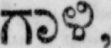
ಗಾಳಿ,
